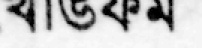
খোঙফম
